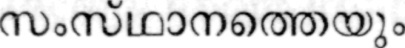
സംസ്ഥാനത്തെയും
